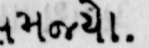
સમજ્યો.
